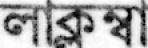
লাক্লম্বা
